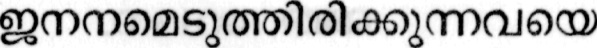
ജനനമെടുത്തിരിക്കുന്നവയെ
